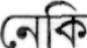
নেকি
